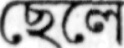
ছেলে
